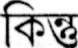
কিন্তু
